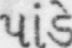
પાંડે
